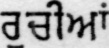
ਰੁਚੀਆਂ
